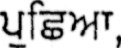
ਪੁਛਿਆ,
